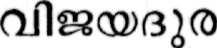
വിജയദുര
